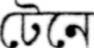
টেনে
